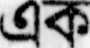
এক
